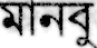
মানবু
